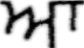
ਆ
